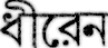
ধীরেন
